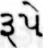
રૂપે
